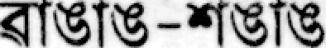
ৱাঙাঙ-শাঙাঙ
